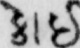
કોઈ
